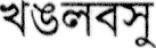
খঙলবসু
